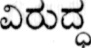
ವಿರುದ್ಧ
